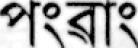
পংৱাং
